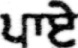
ਪਾਏ
